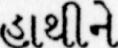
હાથીને
